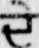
ਦੇ
